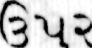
ઉપર
